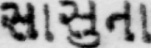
સાસુના
